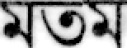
মতম
